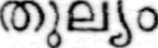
തുല്യം
